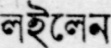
লইলেন
